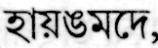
হায়ঙমদে,
